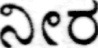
ನೀರ
